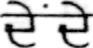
ਦੇਂਦੇ
